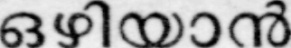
ഒഴിയാന്‍
